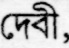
দেবী,
